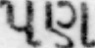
પણ
